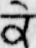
ਕੇ
